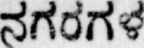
ನಗರಗಳ
